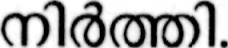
നിര്‍ത്തി.
